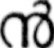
ന്‍
